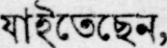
যাইতেছেন,
